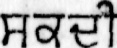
ਸਕਦੀ
